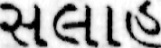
સલાહ
